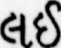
લઈ
